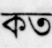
কত
